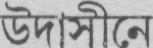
উদাসীনে
